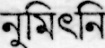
নুমিৎনি
